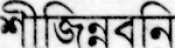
শীজিন্নবনি
